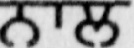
ਨਾਲ
